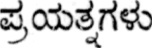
ಪ್ರಯತ್ನಗಳು
